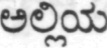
ಅಲ್ಲಿಯ
